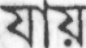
যায়
